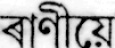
ৰাণীয়ে
